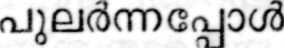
പുലര്‍ന്നപ്പോള്‍
